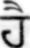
ਹੈ
